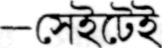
-সেইটেই
